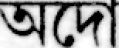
অদো
